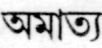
অমাত্য
